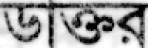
ডাক্তর
